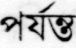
পর্যন্ত
